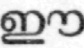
ഈ
